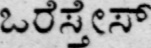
ಒರೆಸ್ತೇಸ್
